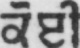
ਕੋਈ
